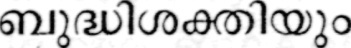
ബുദ്ധിശക്തിയും
